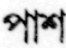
পাশ
